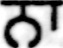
ਨਾ
